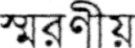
স্মরণীয়
